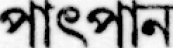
পাৎপান
